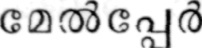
മേല്‍പ്പേര്‍
